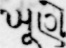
ખૂણે
